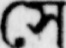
সে
